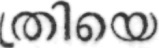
ത്രിയെ
